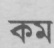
কম
